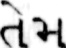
તેમ
